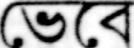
ভেবে
